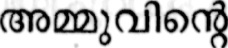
അമ്മുവിന്റെ
